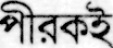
পীরকই
